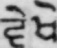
ਵੇਖੋ
